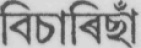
বিচাৰিছাঁ
